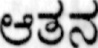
ಆತನ
